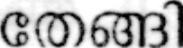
തേങ്ങി
